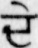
ਦੇ
